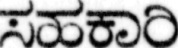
ಸಹಕಾರಿ
